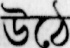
উঠে
